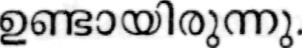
ഉണ്ടായിരുന്നു.
